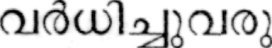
വര്‍ധിച്ചുവരു
